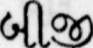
બીજી
